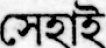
সেহাই
